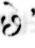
છે'
